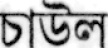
চাউল
